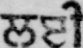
ਲਈ
